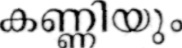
കണ്ണിയും
